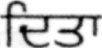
ਦਿਤਾ
